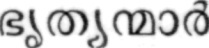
ഭൃത്യന്മാര്‍
